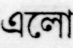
এলো
